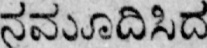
ನಮೂದಿಸಿದ
